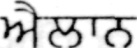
ਐਲਾਨ
